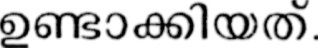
ഉണ്ടാക്കിയത്.
